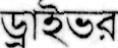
ড্রাইভর
